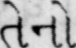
તેનો
